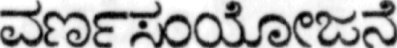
ವರ್ಣಸಂಯೋಜನೆ
